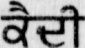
ਕੈਦੀ
